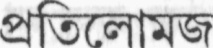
প্রতিলোমজ
